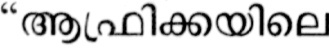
“ആഫ്രിക്കയിലെ
